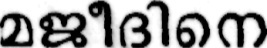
മജീദിനെ
